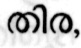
തിര,
